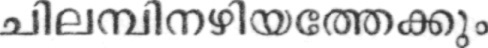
ചിലമ്പിനഴിയത്തേക്കും
